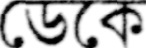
ডেকে
